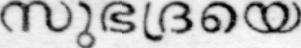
സുഭദ്രയെ
